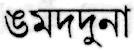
ঙমদদুনা
